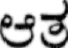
ಆತ
